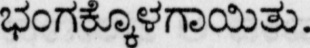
ಭಂಗಕ್ಕೊಳಗಾಯಿತು.
